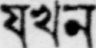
যখন
